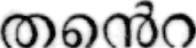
തന്റെ
